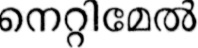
നെറ്റിമേല്‍
